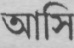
আসি
